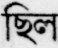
ছিল
